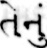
તેનું
